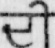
ਦੀ
